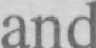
and
